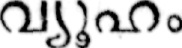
വ്യൂഹം
